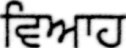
ਵਿਆਹ
